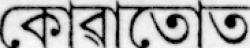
কোৱাতোত
